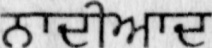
ਨਾਦੀਆਦ
